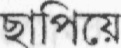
ছাপিয়ে
